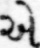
એ
